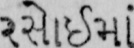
રસોઈમાં
